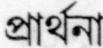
প্রার্থনা
